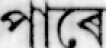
পাৰে
